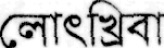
লোৎখ্রিবা
